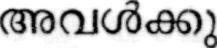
അവള്‍ക്കു
